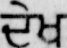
ਦੇਖ
